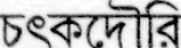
চৎকদৌরি
